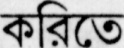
করিতে
